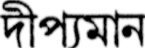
দীপ্যমান
